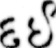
દઈ
